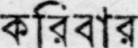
করিবার
